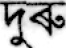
দুৰু
